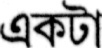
একটা
